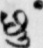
છું
